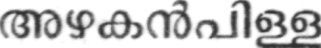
അഴകന്‍പിള്ള
